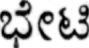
ಭೇಟಿ
